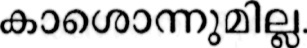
കാശൊന്നുമില്ല.
